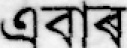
এবাৰ
